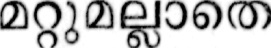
മറ്റുമല്ലാതെ
